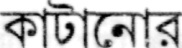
কাটানোর
